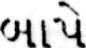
બાપે
